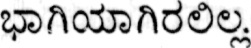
ಭಾಗಿಯಾಗಿರಲಿಲ್ಲ.
